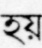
হয়
